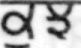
ਕੁਝ
